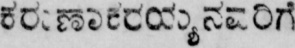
ಕರುಣಾಕರಯ್ಯನವರಿಗೆ
